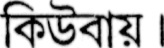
কিউবায়।
